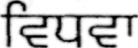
ਵਿਧਵਾ
